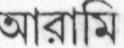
আরামি
